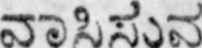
ವಾಸಿಸುವ
